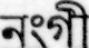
নংগী
